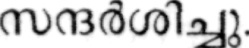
സന്ദര്‍ശിച്ചു.
